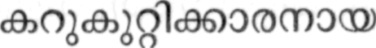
കറുകുറ്റിക്കാരനായ
